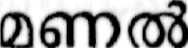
മണല്‍
